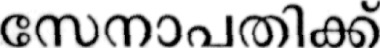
സേനാപതിക്ക്
